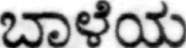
ಬಾಳೆಯ
